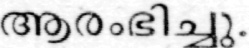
ആരംഭിച്ചു.
